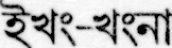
ইখং-খংনা
